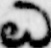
ಎ
